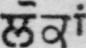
ਲੋਕਾਂ
